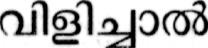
വിളിച്ചാല്‍
